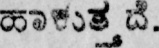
ಹಾಕುತ್ತದೆ.
